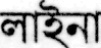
লাইনা
